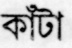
কাঁটা
